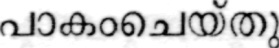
പാകംചെയ്തു
